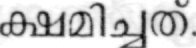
ക്ഷമിച്ചത്.
